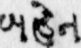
બહેન
